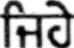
ਜਿਹੇ
